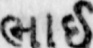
ભાઈ
